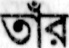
তাঁর
